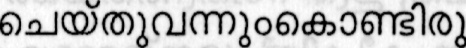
ചെയ്തുവന്നുംകൊണ്ടിരു
